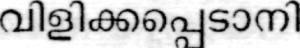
വിളിക്കപ്പെടാനി
